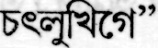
চৎলুখিগে”
